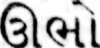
ઊભો
